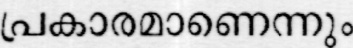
പ്രകാരമാണെന്നും
